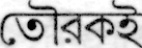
তৌরকই
